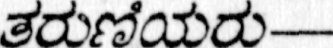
ತರುಣಿಯರು-
